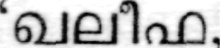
‘ഖലീഫ,
